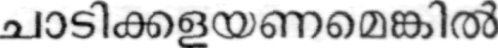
ചാടിക്കളയണമെങ്കില്‍
